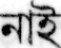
নাই
